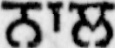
ਨਾਲ
